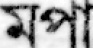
মপা
